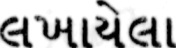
લખાયેલા
